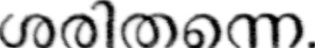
ശരിതന്നെ.
